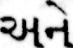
અને
